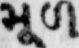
મૂળ
